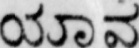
ಯಾವ
